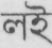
লই
